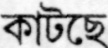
কাটছে
